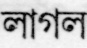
লাগল
